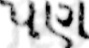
પણ
